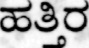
ಹತ್ತಿರ
